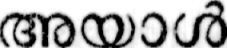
അയാള്‍
